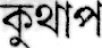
কুথাপ
